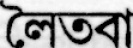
লৈতবা
